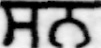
ਸਨ
